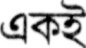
একই
